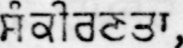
ਸੰਕੀਰਣਤਾ,
